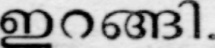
ഇറങ്ങി.
